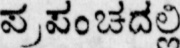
ಪ್ರಪಂಚದಲ್ಲಿ
